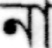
না
